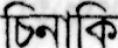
চিনাকি
